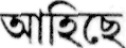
আহিছে
